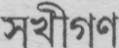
সখীগণ
